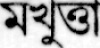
মখুত্তা
